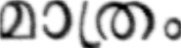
മാത്രം
